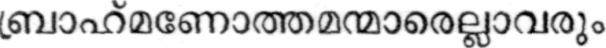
ബ്രാഹ്മണോത്തമന്മാരെല്ലാവരും
